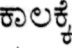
ಕಾಲಕ್ಕೆ
